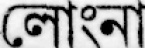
লোংনা
